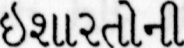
ઇશારતોની
